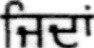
ਜਿਦਾਂ
